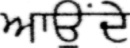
ਆਉਂਦੇ
